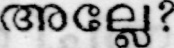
അല്ലേ?
